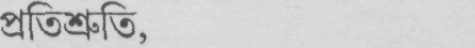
প্ৰতিশ্ৰুতি,
